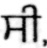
ਸੀ,
